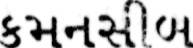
કમનસીબ
